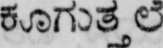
ಕೂಗುತ್ತಲೆ
